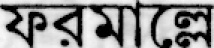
ফরমাল্লে
